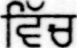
ਵਿੱਚ
